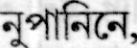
নুপানিনে,
